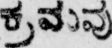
ಕ್ರಮವು
